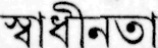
স্বাধীনতা
